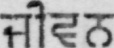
ਜੀਵਨ
